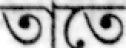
তাতে
